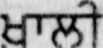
ਖ਼ਾਲੀ
